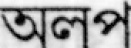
অলপ
